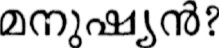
മനുഷ്യന്‍?
